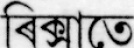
ৰিক্সাতে
